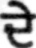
ਦੇ
